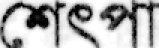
শেৎপা
